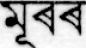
মূৰৰ
